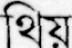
থিয়
